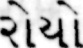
રોયો
